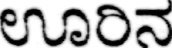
ಊರಿನ
